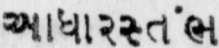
આધારસ્તંભ
